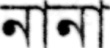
নানা
